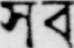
সব
